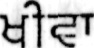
ਖੀਵਾ
